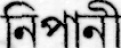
নিপানী
